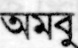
অমবু
